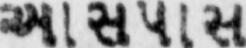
આસપાસ
